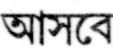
আসবে
